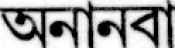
অনানবা
